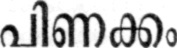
പിണക്കം
